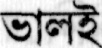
ভালই
